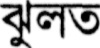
ঝুলত
